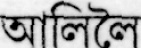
আলিলৈ
